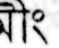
মীং
